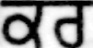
ਕਰ
